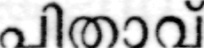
പിതാവ്
